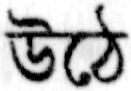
উঠে
